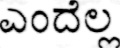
ಎಂದೆಲ್ಲ
